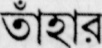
তাঁহার
